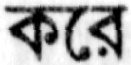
করে
